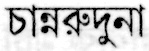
চান্নরুদুনা
